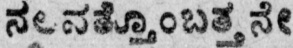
ನಲವತ್ತೊಂಬತ್ತನೇ
